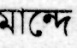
মান্দে
